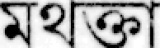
মথক্তা
